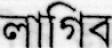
লাগিব
